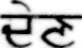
ਦੇਣ
